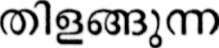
തിളങ്ങുന്ന
